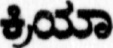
ಕ್ರಿಯಾ
